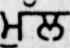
ਮੁੱਲ
